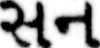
સન
